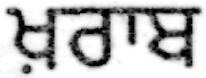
ਖ਼ਰਾਬ
